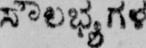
ಸೌಲಭ್ಯಗಳ
